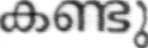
കണ്ടു
